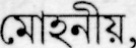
মোহনীয়,
